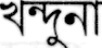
খন্দুনা
